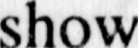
show
